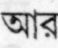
আর
